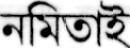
নমিতাই
